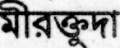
মীরক্তুদা
